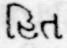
હિત
